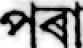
পৰা
